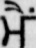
ਮੈਂ
